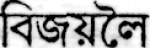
বিজয়লৈ
